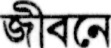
জীবনে
